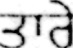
ਤਾਰੇ
